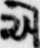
એ
